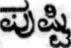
ಪುಷ್ಟಿ
